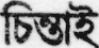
চিন্তাই
